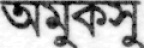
অমুকসু
